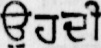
ਉਹਦੀ
